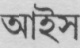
আইস
